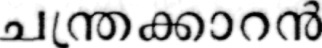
ചന്ത്രക്കാറന്‍
